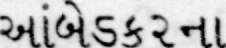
આંબેડકરના
